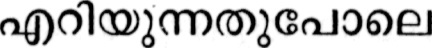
എറിയുന്നതുപോലെ
